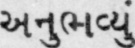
અનુભવ્યું
